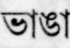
ভাঙা
